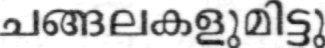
ചങ്ങലകളുമിട്ടു
